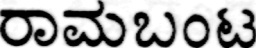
ರಾಮಬಂಟ
